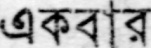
একবার
